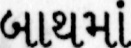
બાથમાં
